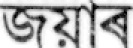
জয়াৰ
